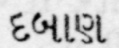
દબાણ
